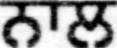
ਨਾਲ
